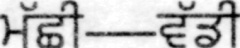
ਮੱਛੀ---ਵੱਡੀ
